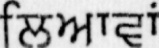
ਲਿਆਵਾਂ
